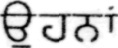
ਉਹਨਾਂ
